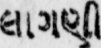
લાગણી
